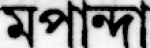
মপান্দা
